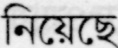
নিয়েছে
